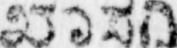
ಖಾಸಗಿ
